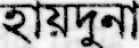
হায়দুনা
